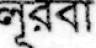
লূরবা
